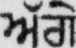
ਅੱਗੇ
